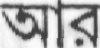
আর
